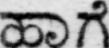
ಹಾಗೆ
